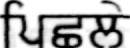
ਪਿਛਲੇ
